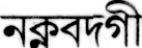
নক্নবদগী
